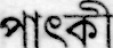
পাৎকী
